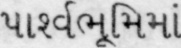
પાર્શ્વભૂમિમાં
